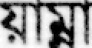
য়াম্না
